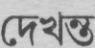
দেখন্ত
